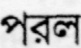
পরল
